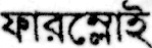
ফারম্লোই
